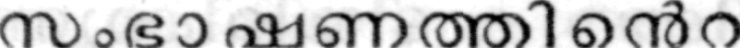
സംഭാഷണത്തിന്റെ
